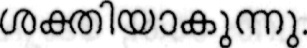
ശക്തിയാകുന്നു.
